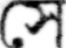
সে
